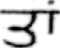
ਤਾਂ
